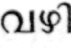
വഴി
